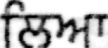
ਲਿਆ
